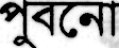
পুবনো
